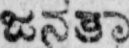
ಜನತಾ
